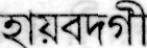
হায়বদগী
